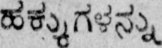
ಹಕ್ಕುಗಳನ್ನು
